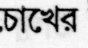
চোখের
